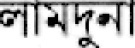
লামদুনা
